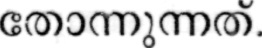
തോന്നുന്നത്.
